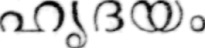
ഹൃദയം
